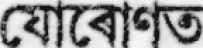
যোৰোণত
